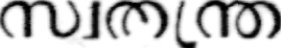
സ്വതന്ത്ര
